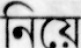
নিয়ে
